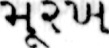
મૂરખ
